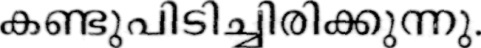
കണ്ടുപിടിച്ചിരിക്കുന്നു.
